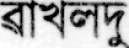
ৱাখলদু
